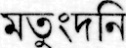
মতুংদনি
